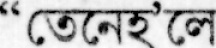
"তেনেহ'লে
